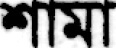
শামা
